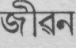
জীৱন
